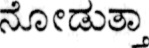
ನೋಡುತ್ತಾ
